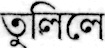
তুলিলে
